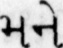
મને
